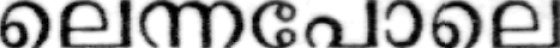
ലെന്നപോലെ
